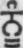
ਨੂੰ
